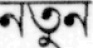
নতুন
